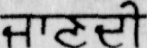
ਜਾਣਦੀ
